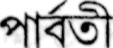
পার্বতী
